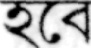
হবে
